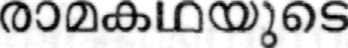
രാമകഥയുടെ
